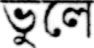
ভুলে
